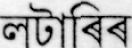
লটাৰিৰ
